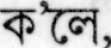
ক'লে,
